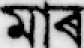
মাৰ
